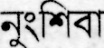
নুংশিবা
